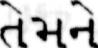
તેમને
